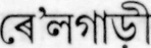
ৰে'লগাড়ী
